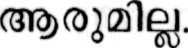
ആരുമില്ല.
